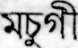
মচুগী
